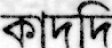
কাদদি
